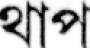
থাপ
